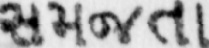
સમજતા
